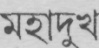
মহাদুখ
